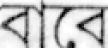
বাবে
